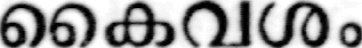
കൈവശം
